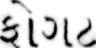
ફોગટ
